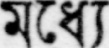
মধ্যে
